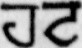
ਹਟ
